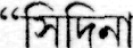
"সিদিনা
